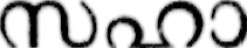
സഹാ
